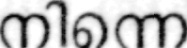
നിന്നെ
